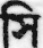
সি
